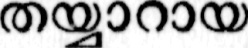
തയ്യാറായ
